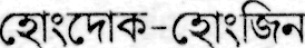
হোংদোক-হোংজিন
